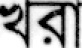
খরা
